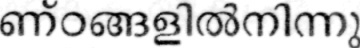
ണ്ഠങ്ങളില്‍നിന്നു
